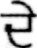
ਦੇ
